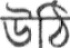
উঠি
